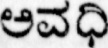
ಅವಧಿ
